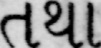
તથા
